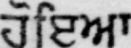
ਹੋਇਆ
